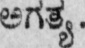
ಅಗತ್ಯ.
